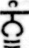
ਨੂੰ
